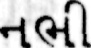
નભી
